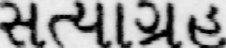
સત્યાગ્રહ
